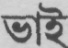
ভাই
